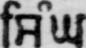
ਸਿੰਘ
